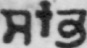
ਸਾਂਭ
